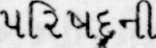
પરિષદની
